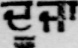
ਦੂਜਾ
